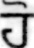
ਹੋ
